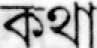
কথা
